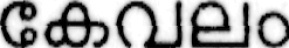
കേവലം
